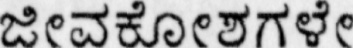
ಜೀವಕೋಶಗಳೇ
